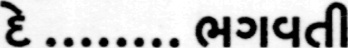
દે.......ભગવતી
